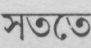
সততে
